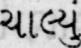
ચાલ્યું
